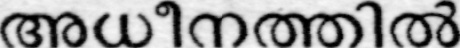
അധീനത്തില്‍
